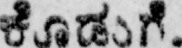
ಕೊಡುಗೆ.
